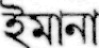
ইমানা
